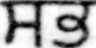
ਸਭ
